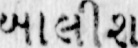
બાલીશ
